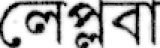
লেপ্লবা
